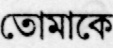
তোমাকে
